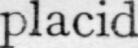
placid
